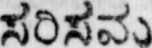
ಸರಿಸಮ
